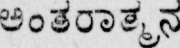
ಅಂತರಾತ್ಮನ
